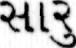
સારુ
